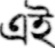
এই
